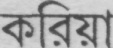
করিয়া
